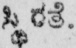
ಸ್ಥಿರತೆ.
